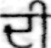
ਦੀ
